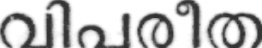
വിപരീത
